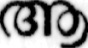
ആ
